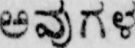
ಅವುಗಳ
